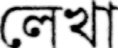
লেখা
